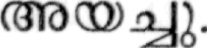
അയച്ചു.
